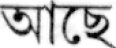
আছে
